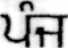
ਪੰਜ
